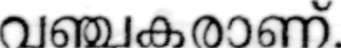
വഞ്ചകരാണ്.
